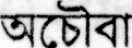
অচৌবা
